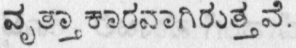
ವೃತ್ತಾಕಾರವಾಗಿರುತ್ತವೆ.
